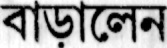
বাড়ালেন
